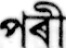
পৰী
